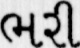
ભરી
